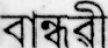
বান্ধৱী
